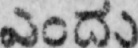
ಎಂದು
